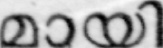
മായി
